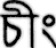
চীং
